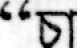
“চা
